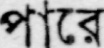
পারে
